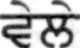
ਵੇਲੇ
